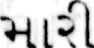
મારી
